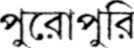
পুরোপুরি
